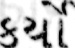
કર્યો
